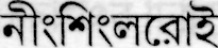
নীংশিংলরোই
